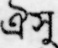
ঐসু
